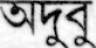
অদুবু
